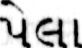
પેલા
